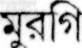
মুরগি
